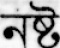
নষ্ট
